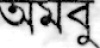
অমবু
